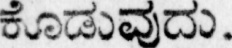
ಕೊಡುವುದು.
